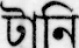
টানি
